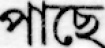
পাছে
